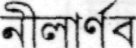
নীলার্ণব
